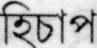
হিচাপ
